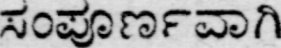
ಸಂಪೂರ್ಣವಾಗಿ
